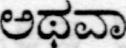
ಅಥವಾ
